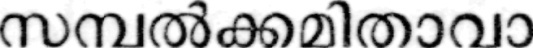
സമ്പല്‍ക്കമിതാവാ
